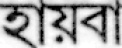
হায়বা
